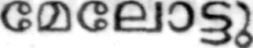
മേലോട്ടു
